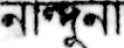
নান্দুনা
